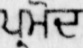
ਪ੍ਰਮੋਦ
